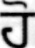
ਹੋ
